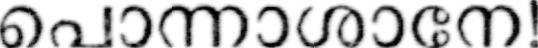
പൊന്നാശാനേ!
